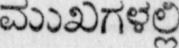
ಮುಖಗಳಲ್ಲಿ
